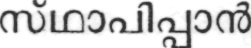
സ്ഥാപിപ്പാന്‍
